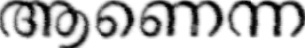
ആണെന്ന
